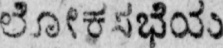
ಲೋಕಸಭೆಯ
